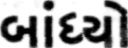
બાંધ્યો
